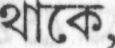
থাকে,
